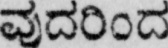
ವುದರಿಂದ
